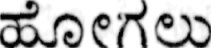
ಹೋಗಲು
